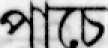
পাচে
